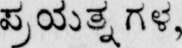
ಪ್ರಯತ್ನಗಳ,
